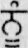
ਨੂੰ
